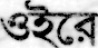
ওইরে
